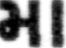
મા
